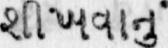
શીખવાનું
